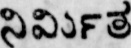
ನಿರ್ಮಿತ
